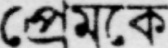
প্রেমকে
